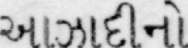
આઝાદીનો
